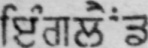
ਇੰਗਲੈਂਡ
